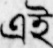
এই
